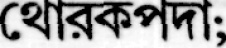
থোরকপদা;
